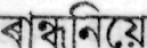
ৰান্ধনিয়ে
